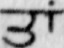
ਤਾਂ
